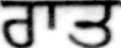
ਰਾਤ
